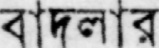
বাদলার
